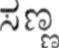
ಸಣ್ಣ
